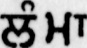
ਲੰਮਾ
